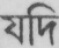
যদি
